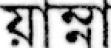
য়াম্না
